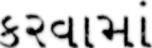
કરવામાં
